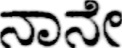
ನಾನೇ
